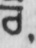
ਰੋ,
